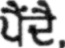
ਪੈਂਦੈ,
